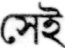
সেই
